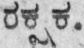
ರಕ್ಷಕ.
